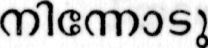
നിന്നോടു
